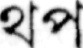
থপ
